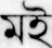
মই
